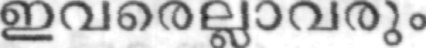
ഇവരെല്ലാവരും
